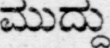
ಮುದ್ದು
